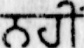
ਨਹੀਂ
